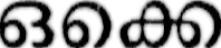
ഒക്കെ
